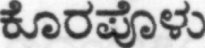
ಕೊರಪೊಳು
